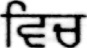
ਵਿਚ
